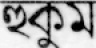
হুকুম
